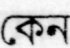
কেন
